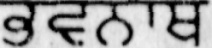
ਭਵਨਾਥ
